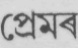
প্ৰেমৰ
